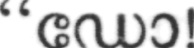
"ഡോ!
